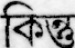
কিন্তু
